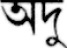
অদু
